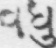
વધુ
